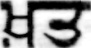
ਖ਼ਤ
